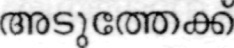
അടുത്തേക്ക്
